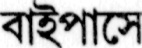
বাইপাসে
